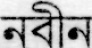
নবীন
